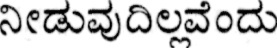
ನೀಡುವುದಿಲ್ಲವೆಂದು
